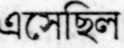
এসেছিল
